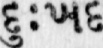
દુઃખદ
